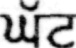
ਘੱਟ
